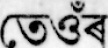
তেওঁৰ
